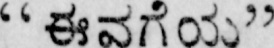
“ಈವಗೆಯ"
